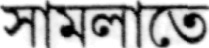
সামলাতে
